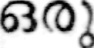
ഒരു
